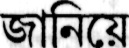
জানিয়ে
